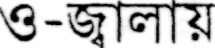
ও-জ্বালায়
